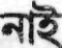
নাই
